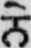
ਨੇ
